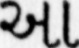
આ
